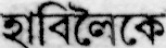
হাবিলৈকে
